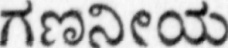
ಗಣನೀಯ
